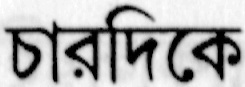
চারদিকে
